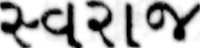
સ્વરાજ
